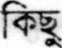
কিছু
